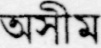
অসীম
